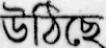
উঠিছে
